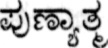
ಪುಣ್ಯಾತ್ಮ
